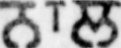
ਨਾਲ
